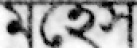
মহেস
